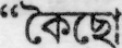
"কৈছো
